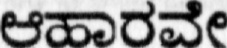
ಆಹಾರವೇ
